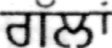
ਗੱਲਾਂ
